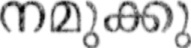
നമുക്കു
